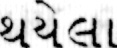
થયેલા
